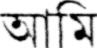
আমি
